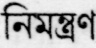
নিমন্ত্রণ
